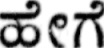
ಹೇಗೆ
